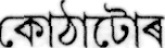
কোঠাটোৰ
